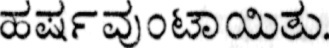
ಹರ್ಷವುಂಟಾಯಿತು.
